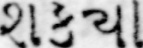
શક્યા
